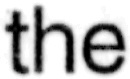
the
